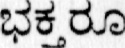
ಭಕ್ತರೂ
